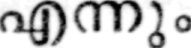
എന്നും
